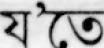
য'তে
